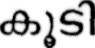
കൂടി
